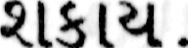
શકાય.
